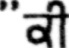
''ਕੀ
